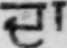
ਦਾ
